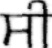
ਸੀ
